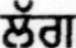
ਲੱਗ
